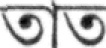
তাত
